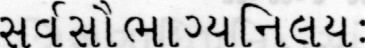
સર્વસૌભાગ્યનિલયઃ
